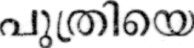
പുത്രിയെ
